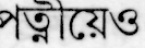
পত্নীয়েও
